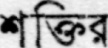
শক্তির
